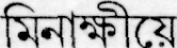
মিনাক্ষীয়ে
